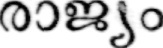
രാജ്യം
